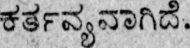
ಕರ್ತವ್ಯವಾಗಿದೆ.
